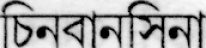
চিনবানসিনা
